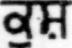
ਕੁਸ਼
